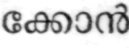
ക്കോന്‍
